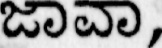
ಜಾವಾ,
